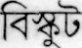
বিস্কুট
